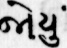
જોયું
